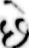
છે
